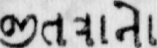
જીતવાનો
